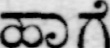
ಹಾಗೆ
